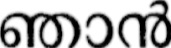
ഞാന്‍
